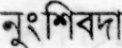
নুংশিবদা
